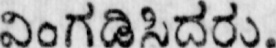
ವಿಂಗಡಿಸಿದರು.
